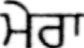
ਮੇਰਾ
